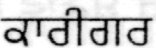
ਕਾਰੀਗਰ
